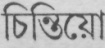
চিন্তিয়ো
